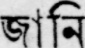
জানি
